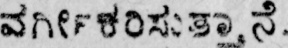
ವರ್ಗೀಕರಿಸುತ್ತಾನೆ.
